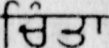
ਚਿੰਤਾ
